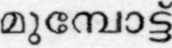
മുമ്പോട്ട്
